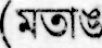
(মতাঙ
